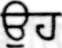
ਉਹ
